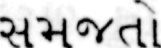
સમજતો
